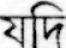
যদি
